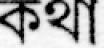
কথা
